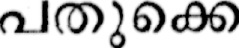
പതുക്കെ
